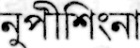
নুপীশিংনা
